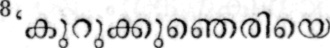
8'കുറുക്കുഞെരിയെ
